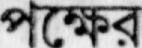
পক্ষের
